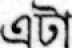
এটা
